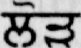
ਲੋੜ
